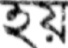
হয়
